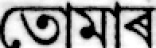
তোমাৰ
